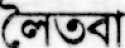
লৈতবা
